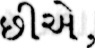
છીએ,
